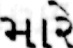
મારે
